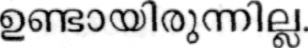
ഉണ്ടായിരുന്നില്ല.
